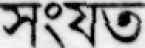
সংযত
